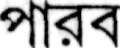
পারব
